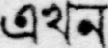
এখন
